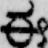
ಈ
